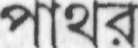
পাথর
